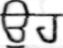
ਉਹ
